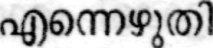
എന്നെഴുതി
